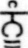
ਨੂੰ
